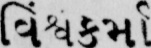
વિશ્વકર્મા
